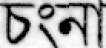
চংনা
